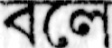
বলে
